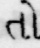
તો
